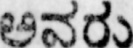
ಅವರು
